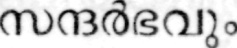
സന്ദര്‍ഭവും
